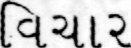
વિચાર
